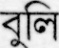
বুলি
